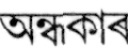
অন্ধকাৰ
